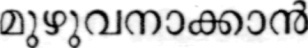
മുഴുവനാക്കാന്‍
